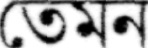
তেমন
